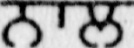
ਨਾਲ
